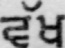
ਵੱਖ
